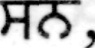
ਸਨ,
